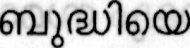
ബുദ്ധിയെ
